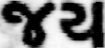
જય
